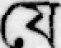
যে
